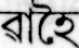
ৱাহৈ
